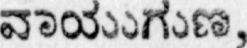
ವಾಯುಗುಣ,
